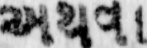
અથવા
